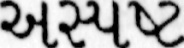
અસ્પષ્ટ
